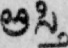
ಅಸ್ತಿ
